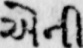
એની
